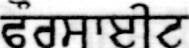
ਫੌਰਸਾਈਟ
